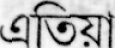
এতিয়া
